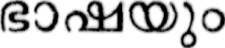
ഭാഷയും
